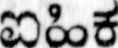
ಐಹಿಕ
